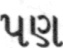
પણ
